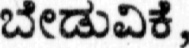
ಬೇಡುವಿಕೆ,
